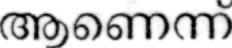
ആണെന്ന്
